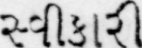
સ્વીકારી
